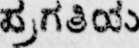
ಪ್ರಗತಿಯ
